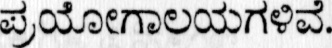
ಪ್ರಯೋಗಾಲಯಗಳಿವೆ.
